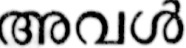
അവള്‍
